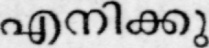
എനിക്കു
